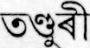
তণ্ডুৰী
